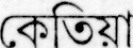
কেতিয়া
